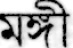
মঙ্গী
